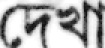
দেখা
